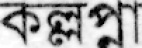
কল্লপ্না
